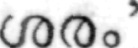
ശരം'
